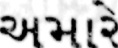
અમારે
